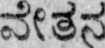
ವೇತನ
